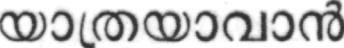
യാത്രയാവാന്‍
